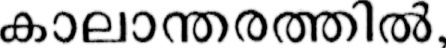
കാലാന്തരത്തില്‍,
